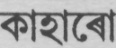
কাহাৰো
